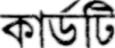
কার্ডটি
